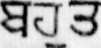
ਬਹੁਤ
